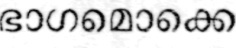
ഭാഗമൊക്കെ
